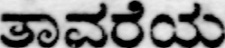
ತಾವರೆಯ
